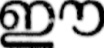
ഈ
